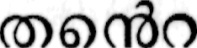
തന്റെ
